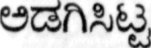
ಅಡಗಿಸಿಟ್ಟ
